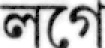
লগে
